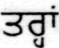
ਤਰ੍ਹਾਂ
